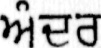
ਅੰਦਰ
